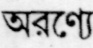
অরণ্যে
